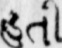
હતી
